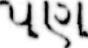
પણ
